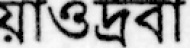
য়াওদ্রবা
